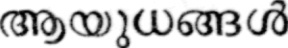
ആയുധങ്ങള്‍
